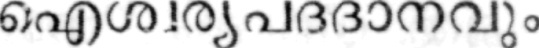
ഐശ്വര്യപദദാനവും
